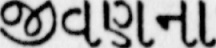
જીવણના
